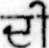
ਦੀ
